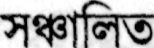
সঞ্চালিত
